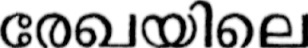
രേഖയിലെ
